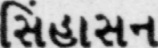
સિંહાસન
